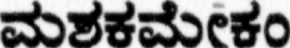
ಮಶಕಮೇಕಂ
